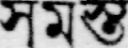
সমস্ত
